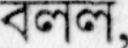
বলল,
